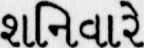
શનિવારે
